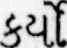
કર્યો
